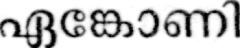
ഏങ്കോണി
